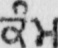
ਕੰਮ
